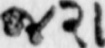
જરા
